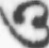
ও
